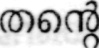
തന്റെ
